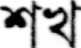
শখ
